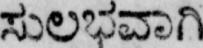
ಸುಲಭವಾಗಿ
